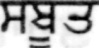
ਸਬੂਤ
